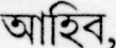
আহিব,
